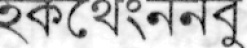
হকথেংননবু
